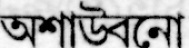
অশাউবনো
